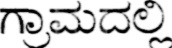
ಗ್ರಾಮದಲ್ಲಿ
